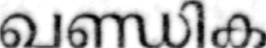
ഖണ്ഡിക
